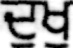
ਦੁਖੁ
